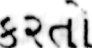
કરતો
